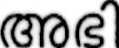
അഭി
